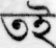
তই
